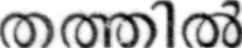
തത്തില്‍
